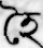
হৈ
